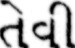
તેવી
